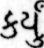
કર્યું
